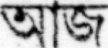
আজ
